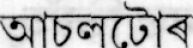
আচলটোৰ
